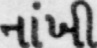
નાંખી
